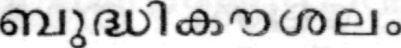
ബുദ്ധികൌശലം
